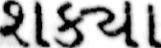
શક્યા
